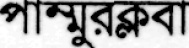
পাম্মুরক্লবা
